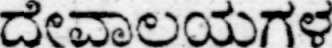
ದೇವಾಲಯಗಳ
